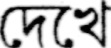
দেখে
